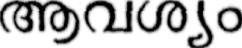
ആവശ്യം
